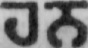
ਹਨ
